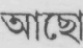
আছো
